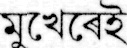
মুখেৰেই
